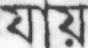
যায়
